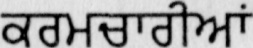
ਕਰਮਚਾਰੀਆਂ
